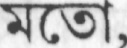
মতো,
